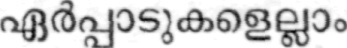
ഏര്‍പ്പാടുകളെല്ലാം
